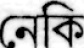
নেকি
